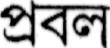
প্রবল
